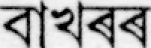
বাখৰৰ
